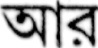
আর
